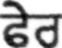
ਫੇਰ
